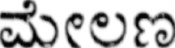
ಮೇಲಣ
